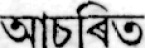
আচৰিত
